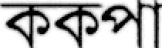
ককপা
